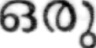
ഒരു
